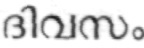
ദിവസം
